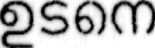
ഉടനെ
